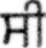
ਸੀ
